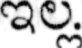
ಇಲ್ಲ.
